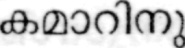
കമറിനു
